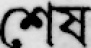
শেষ
